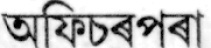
অফিচৰপৰা
